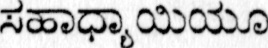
ಸಹಾಧ್ಯಾಯಿಯೂ
